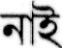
নাই
